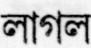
লাগল
